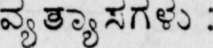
ವ್ಯತ್ಯಾಸಗಳು:
